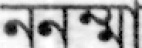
ননম্মা
